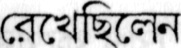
রেখেছিলেন
